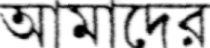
আমাদের
